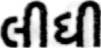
લીધી
